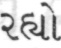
રહ્યો
